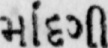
માંદગી
